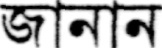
জানান
